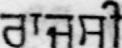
ਰਾਜਸੀ
